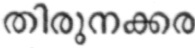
തിരുനക്കര
